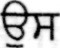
ਉਸ
